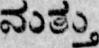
ಮತ್ತು
